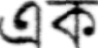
এক
